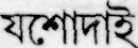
যশোদাই
